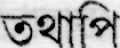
তথাপি
